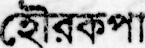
হৌরকপা
